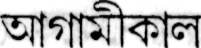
আগামীকাল
